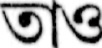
তাও
